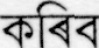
কৰিব
